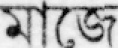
মাজে
